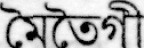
মৈতৈগী
